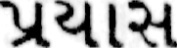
પ્રયાસ
